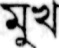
মুখ
